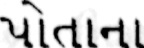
પોતાના
